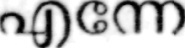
എന്നേ
